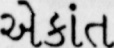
એકાંત
